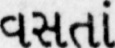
વસતાં
